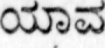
ಯಾವ
